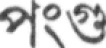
পংগু
